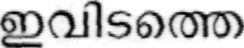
ഇവിടത്തെ
